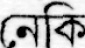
নেকি
